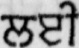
ਲਈ
